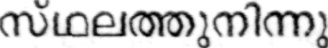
സ്ഥലത്തുനിന്നു
